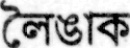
লৈঙাক
